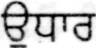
ਉਧਾਰ
